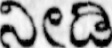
ನೀಡಿ
